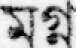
মগ্ন
